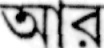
আর
